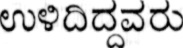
ಉಳಿದಿದ್ದವರು
